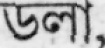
ডলা,
